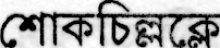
শোকচিল্লক্লে
